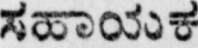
ಸಹಾಯಕ
